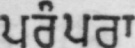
ਪਰੰਪਰਾ
